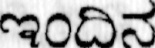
ಇಂದಿನ
